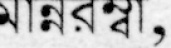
মান্নরম্বা,
